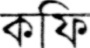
কফি
